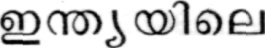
ഇന്ത്യയിലെ
